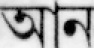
আন
